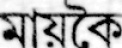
মায়কৈ
